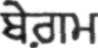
ਬੇਗ਼ਮ
